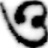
ও
